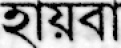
হায়বা
